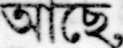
আছে,
